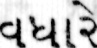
વધારે
